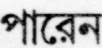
পারেন
